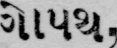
ગોપથ,
